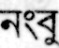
নংবু
